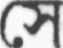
সে
